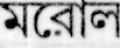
মরোল
